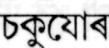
চকুযোৰ
